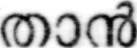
താന്‍
